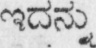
ಇದನ್ನು
